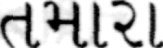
તમારા
